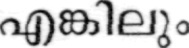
എങ്കിലും
